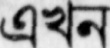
এখন
